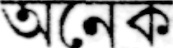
অনেক
